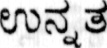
ಉನ್ನತ
